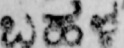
ಬಹಳ
